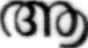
ആ
